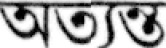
অত্যন্ত
